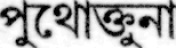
পুথোক্তুনা
